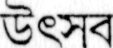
উৎসব
